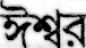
ঈশ্বর
